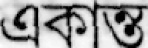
একান্ত
